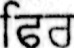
ਫਿਰ
